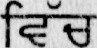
ਵਿੱਚ
